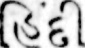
હિંદી
